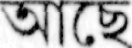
আছে
